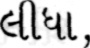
લીધા,
